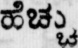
ಹೆಚ್ಚು
